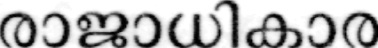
രാജാധികാര
